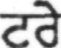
ਟਰੇ
